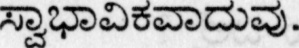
ಸ್ವಾಭಾವಿಕವಾದುವು.
